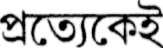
প্রত্যেকেই
